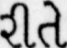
રીતે
